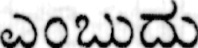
ಎಂಬುದು
